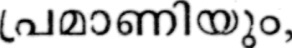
പ്രമാണിയും,
